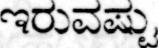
ಇರುವಷ್ಟು
